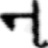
ન
